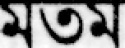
মতম
